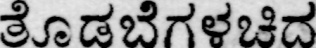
ತೊಡಬೆಗಳಚಿದ
